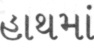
હાથમાં
